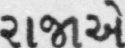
રાજાએ
